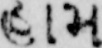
હામ
